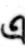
এ
